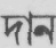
দান
